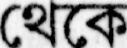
থেকে
